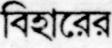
বিহারের
